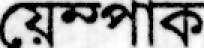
য়েম্পাক
